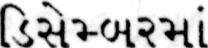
ડિસેમ્બરમાં
